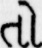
તો
